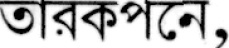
তারকপনে,
